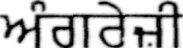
ਅੰਗਰੇਜ਼ੀ
